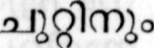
ചുറ്റിനും
